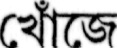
খোঁজে
